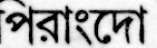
পিরাংদো
